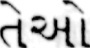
તેઓ
